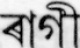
ৰাগী
